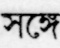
সঙ্গে
